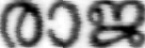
രാജ
